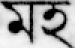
মহ
